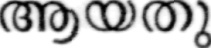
ആയതു
